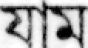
যাম
